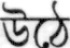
উঠে
